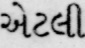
એટલી
